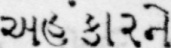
અહંકારને
